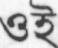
ওই
